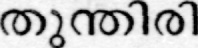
തുന്തിരി
